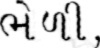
ભેળી,
